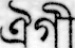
ঐগী
